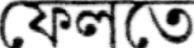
ফেলতে
